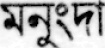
মনুংদা
